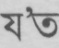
য'ত
